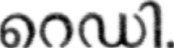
റെഡി.
